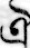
ঐ
